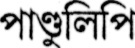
পাণ্ডুলিপি
